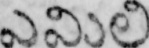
ಎಮಿಲಿ
